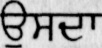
ਉਸਦਾ
